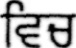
ਵਿਚ
